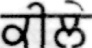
ਕੀਲੇ
